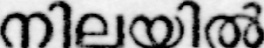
നിലയില്‍
